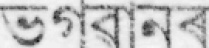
ভগৱানৰ
